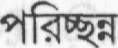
পরিচ্ছন্ন
